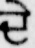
ਦੇ
